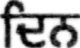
ਦਿਨ
